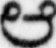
ಆ
